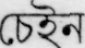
চেইন
